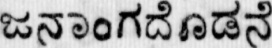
ಜನಾಂಗದೊಡನೆ
